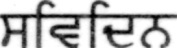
ਸਵਿਦਿਨ
